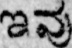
ಇವು
